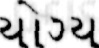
યોગ્ય
